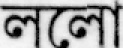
ললো
